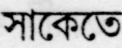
সাকেতে
